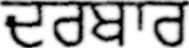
ਦਰਬਾਰ
